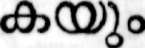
കയും
